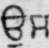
ਉਸ
